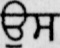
ਉਸ
